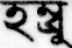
হম্ব্রু
